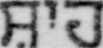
ਸ਼ਾਹ
